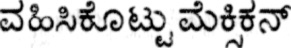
ವಹಿಸಿಕೊಟ್ಟುಮೆಕ್ಸಿಕನ್
